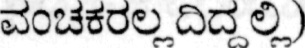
ವಂಚಕರಲ್ಲದಿದ್ದಲ್ಲಿ)
